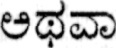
ಅಥವಾ
